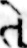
તે
